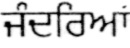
ਜੰਦਰਿਆਂ
